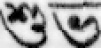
শুভ
